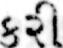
કરી
